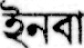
ইনবা
